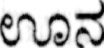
ಊನ
